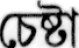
চেষ্টা
